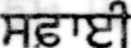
ਸਫ਼ਾਈ
